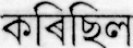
কৰিছিল
